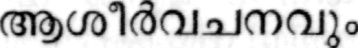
ആശീര്‍വചനവും
